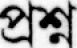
প্রশ্ন
